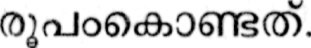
രൂപംകൊണ്ടത്.
